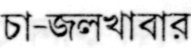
চা-জলখাবার
